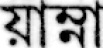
য়াম্না
